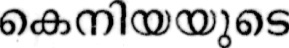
കെനിയയുടെ
